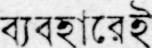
ব্যবহারেই
